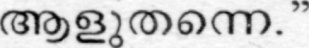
ആളുതന്നെ.''
